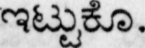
ಇಟ್ಟುಕೊ.
